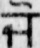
ਜੋ
